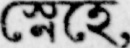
স্নেহে,
